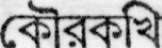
কৌরকখি
